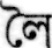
লৈ
